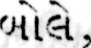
બોલે,
